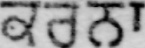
ਕਰਨਾ
